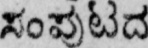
ಸಂಪುಟದ
